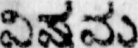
ವಿಷಮ
